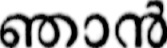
ഞാന്‍
